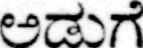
ಅಡುಗೆ
